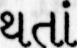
થતાં
